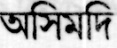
অসিমদি
